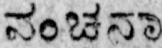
ವಂಚನಾ
